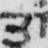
ਤਾਂ
